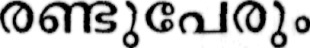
രണ്ടുപേരും
